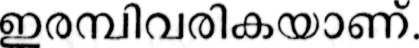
ഇരമ്പിവരികയാണ്.
